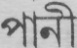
পানী
